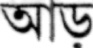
আড়
